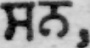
ਸਨ,
